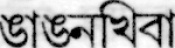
ঙাঙনখিবা
